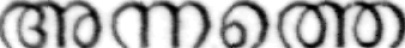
അന്നത്തെ
